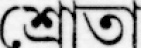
শ্রোতা
